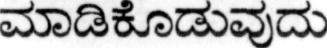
ಮಾಡಿಕೊಡುವುದು
